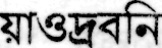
য়াওদ্রবনি
